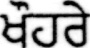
ਖੌਹਰੇ
